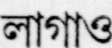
লাগাও
